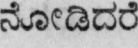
ನೋಡಿದರೆ
